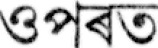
ওপৰত
